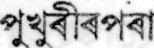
পুখুৰীৰপৰা
